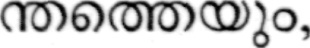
ന്തത്തെയും,
